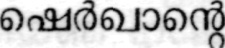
ഷെര്‍ഖാന്റെ
